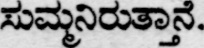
ಸುಮ್ಮನಿರುತ್ತಾನೆ.
